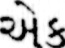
એક
